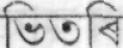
ভিতৰি
